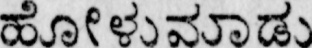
ಹೋಳುಮಾಡು
